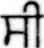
ਸੀ
